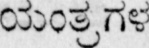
ಯಂತ್ರಗಳ
